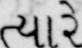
ત્યારે
